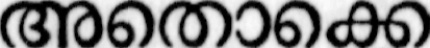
അതൊക്കെ
